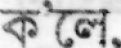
ক'লে,
